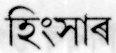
হিংসাৰ
